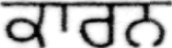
ਕਾਰਨ
